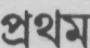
প্ৰথম
